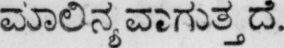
ಮಾಲಿನ್ಯವಾಗುತ್ತದೆ.
